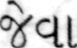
જેવા
